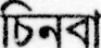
চিনবা
